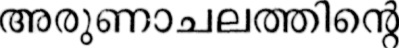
അരുണാചലത്തിന്റെ
